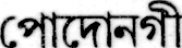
পোদোনগী
